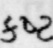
કષ્ટ
